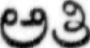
ಅತಿ
